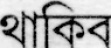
থাকিব
